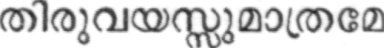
തിരുവയസ്സുമാത്രമേ
